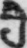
ਹੈ
